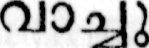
വാച്ചു
